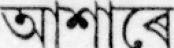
আশাৰে
